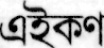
এইকণ
